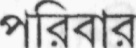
পরিবার
